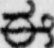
ಈ
